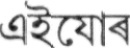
এইযোৰ
